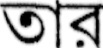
তার
